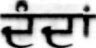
ਦੰਦਾਂ
